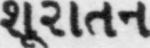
શૂરાતન
